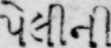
પેલીના
